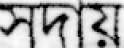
সদায়
